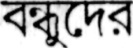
বন্ধুদের
